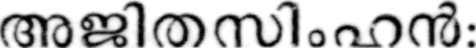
അജിതസിംഹന്‍:
